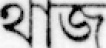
থাজ
